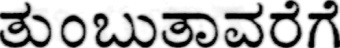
ತುಂಬುತಾವರೆಗೆ
